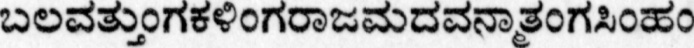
ಬಲವತ್ತುಂಗಕಳಿಂಗರಾಜಮದವನ್ಮಾತಂಗಸಿಂಹಂ
